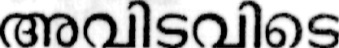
അവിടവിടെ
